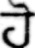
ਹੋ
